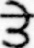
ਤੇ
